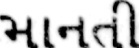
માનતી
